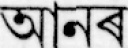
আনৰ
